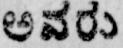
ಅವರು
